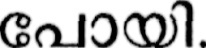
പോയി.
